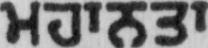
ਮਹਾਨਤਾ
